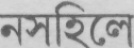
নসহিলে
